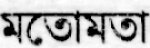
মতোমতা
